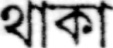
থাকা
